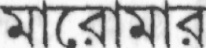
মারোমার
